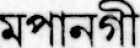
মপানগী
